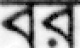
বর
